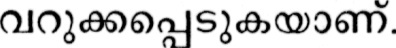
വറുക്കപ്പെടുകയാണ്.
